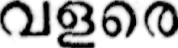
വളരെ
